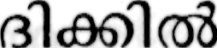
ദിക്കില്‍
